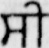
ਸੀ
